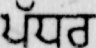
ਪੱਧਰ
